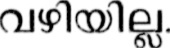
വഴിയില്ല.
